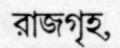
রাজগৃহ,
